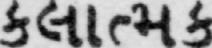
કલાત્મક
